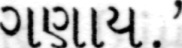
ગણાય.'
